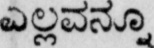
ಎಲ್ಲವನ್ನೂ
